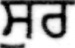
ਸੁਰ
